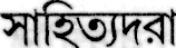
সাহিত্যদরা
